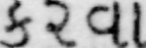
કરવા
